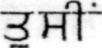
ਤੁਸੀਂ
